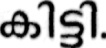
കിട്ടി.
